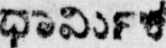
ಧಾರ್ಮಿಕ
